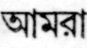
আমরা
